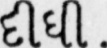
દીધી.
